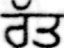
ਰੱਤ
